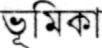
ভূমিকা
